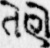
તેણે
